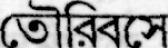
তৌরিবসে
